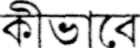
কীভাবে
